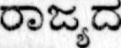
ರಾಜ್ಯದ
